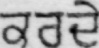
ਕਰਦੇ
